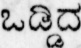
ಒಡ್ಡಿದ
